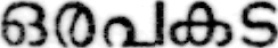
ഒരപകട
